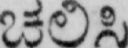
ಚಲಿಸಿ
